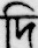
দি
